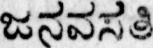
ಜನವಸತಿ
